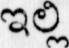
ಇಲ್ಲಿ
